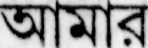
আমার
